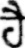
ਹੈ
